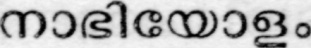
നാഭിയോളം
